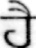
ਹੈ
